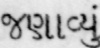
જણાવ્યું
